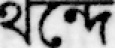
থন্দে
